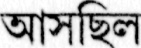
আসছিল
